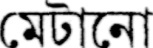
মেটানো
